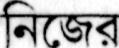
নিজের
